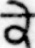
ਕੇ
